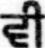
ਵੀ
